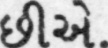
છીએ.
